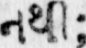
નથી:
